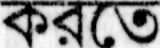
করতে
